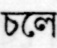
চলে
